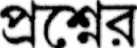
প্রশ্নের
